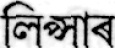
লিপ্সাৰ
